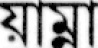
য়াম্না
